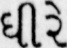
ધીરે
